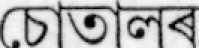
চোতালৰ
